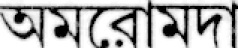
অমরোমদা
